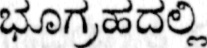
ಭೂಗ್ರಹದಲ್ಲಿ
